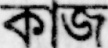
কাজ
